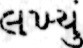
લખ્યું
